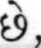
છે,
